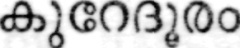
കുറേദൂരം
